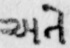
અને
